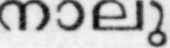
നാലു
